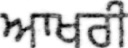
ਆਖਰੀ
